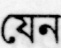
যেন
